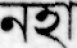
নহা
